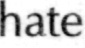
hate
